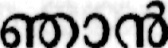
ഞാന്‍
